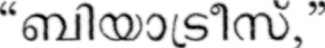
“ബിയാട്രീസ്,"
